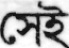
সেই
